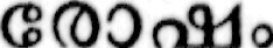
രോഷം
